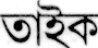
তাইক
